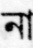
না
